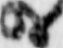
જ
